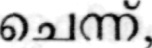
ചെന്ന്,
